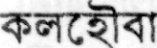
কলহৌবা
